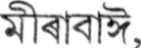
মীৰাবাঈ,
